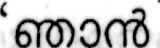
'ഞാന്‍
